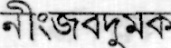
নীংজবদুমক
